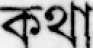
কথা
